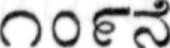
೧೦೯ನೆ
